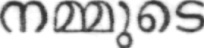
നമ്മുടെ
